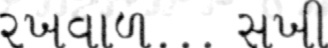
રખવાળ...સખી
